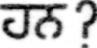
ਹਨ?
